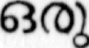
ഒരു
